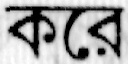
করে
